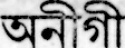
অনীগী
